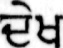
ਦੇਖ
